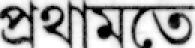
প্রথামতে
